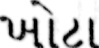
ખોટા
